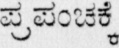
ಪ್ರಪಂಚಕ್ಕೆ
